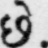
છે.
